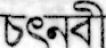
চৎনবী
